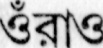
ওঁরাও
